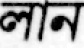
লান
